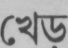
খেড়
